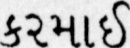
કરમાઈ
